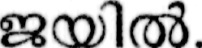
ജയില്‍.
